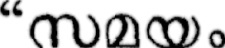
“സമയം
